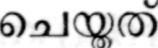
ചെയ്തത്
